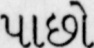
પાછો
